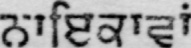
ਨਾਇਕਾਵਾਂ
